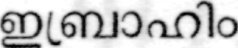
ഇബ്രാഹിം
